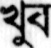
খুব
